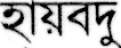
হায়বদু
